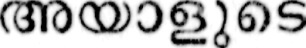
അയാളുടെ
